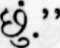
છું."
